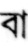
বা
